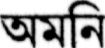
অমনি
